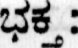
ಭಕ್ತ:
